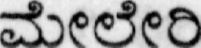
ಮೇಲೇರಿ
